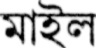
মাইল
